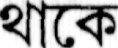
থাকে
